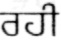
ਰਹੀ
